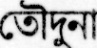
তৌদুনা
